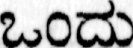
ಒಂದು
